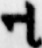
ન
